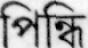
পিন্ধি
